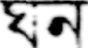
ঘন
